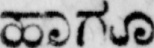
ಹಾಗೂ
